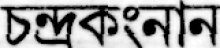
চন্দ্রকংনান
